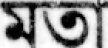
মতা
